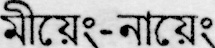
মীয়েং-নায়েং
